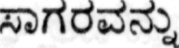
ಸಾಗರವನ್ನು
